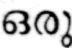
ഒരു
